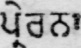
ਪ੍ਰੇਰਨਾ
